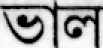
ভাল
